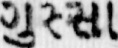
ગુસ્સા
